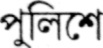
পুলিশে
